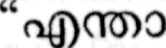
“എന്താ
